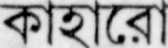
কাহারো
